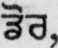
ਡੋਰ,
